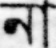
না
